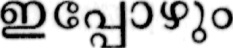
ഇപ്പോഴും
